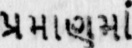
પ્રમાણમાં
